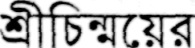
শ্রীচিন্ময়ের
